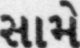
સામે
